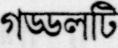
গড্ডলটি
